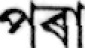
পৰা
